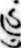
હું
